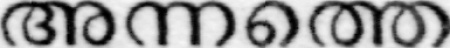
അന്നത്തെ
